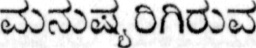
ಮನುಷ್ಯರಿಗಿರುವ
